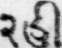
રહી
